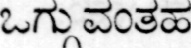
ಒಗ್ಗುವಂತಹ
